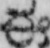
ಈ
